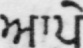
ਆਪੇ
